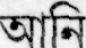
আনি
